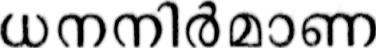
ധനനിര്‍മാണ
